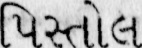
પિસ્તોલ
